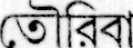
তৌরিবা
